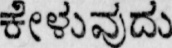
ಕೇಳುವುದು
